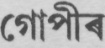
গোপীৰ
